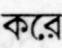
করে
